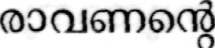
രാവണന്റെ
